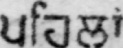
ਪਹਿਲਾਂ
